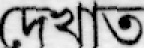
দেখাত
